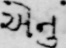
એનું
